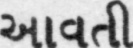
આવતી
